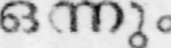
ഒന്നും
